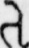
તે
